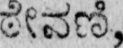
ಠೇವಣಿ,
